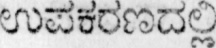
ಉಪಕರಣದಲ್ಲಿ
